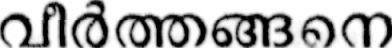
വീര്‍ത്തങ്ങനെ
